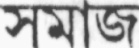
সমাজ
